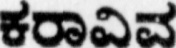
ಕರಾವಿವ
